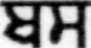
ਬਸ
